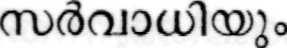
സര്‍വാധിയും
